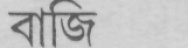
বাজি
